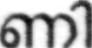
ണി
